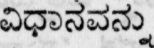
ವಿಧಾನವನ್ನು
